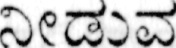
ನೀಡುವ
